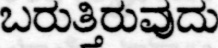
ಬರುತ್ತಿರುವುದು
